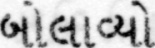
બોલાવ્યો
